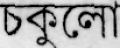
চকুলো
